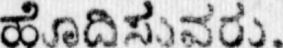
ಹೊದಿಸುವರು.
